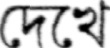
দেখে
